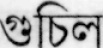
গুচিল
